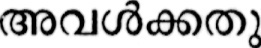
അവള്‍ക്കതു
